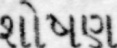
શોષણ
